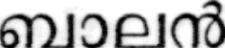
ബാലന്‍
